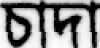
চাদা
